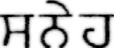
ਸਨੇਹ
